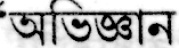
‘অভিজ্ঞান
